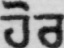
ਹੋਰ
